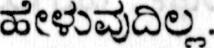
ಹೇಳುವುದಿಲ್ಲ.
